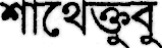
শাথেক্তুবু
